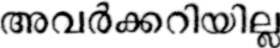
അവര്‍ക്കറിയില്ല.
